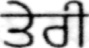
ਤੇਰੀ
